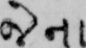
જેના
